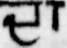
ਦਾ
